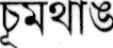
চূমথাঙ
